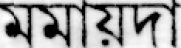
মমায়দা
